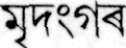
মৃদংগৰ
